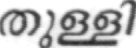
തുള്ളി
